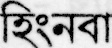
হিংনবা
